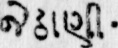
જેઠાણી.
